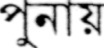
পুনায়
